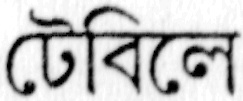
টেবিলে
